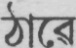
ঠাৱে
